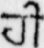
ਹੀ
